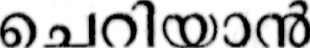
ചെറിയാന്‍
